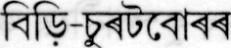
বিড়ি-চুৰটবোৰৰ
